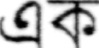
এক
